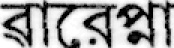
ৱারেপ্না
